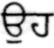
ਉਹ
